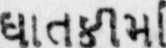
ઘાતકીમા
